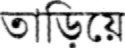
তাড়িয়ে
